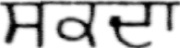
ਸਕਦਾ
